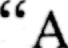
"A
